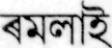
ৰমলাই
